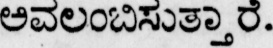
ಅವಲಂಬಿಸುತ್ತಾರೆ.
